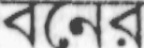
বনের
